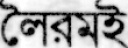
লৈরমই
